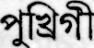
পুখ্রিগী
